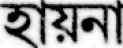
হায়না
